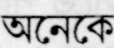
অনেকে
